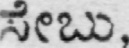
ಸೇಬು,
